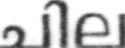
ചില
